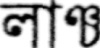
লাঞ্চ
